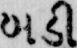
બડી
